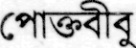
পোক্তবীবু
